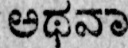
ಅಥವಾ
